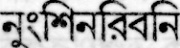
নুংশিনরিবনি
